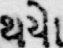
થયો
